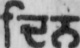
ਦਿਨ
